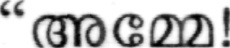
"അമ്മേ!
